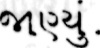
જાણ્યું.
